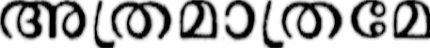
അത്രമാത്രമേ
